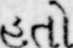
હતો
